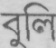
বুলি
